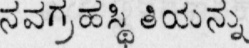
ನವಗ್ರಹಸ್ಥಿತಿಯನ್ನು
